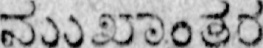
ಮೂಖಾಂತರ
